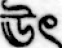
ঊৎ
